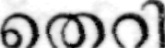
തെറി
